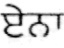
ਏਨਾ
